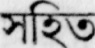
সহিত
